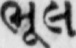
ભૂલ
